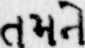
તમને
